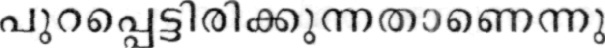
പുറപ്പെട്ടിരിക്കുന്നതാണെന്നു
